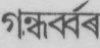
গন্ধৰ্ব্বৰ
